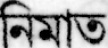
নিমাত
